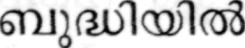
ബുദ്ധിയില്‍
